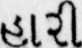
હારી
